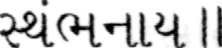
સ્થંભનાય।।
